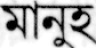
মানুহ
